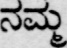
ನಮ್ಮ
